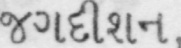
જગદીશન,
